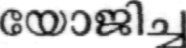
യോജിച്ച
